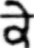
ਕੇ
